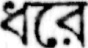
ধরে
